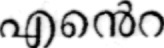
എന്റെ
